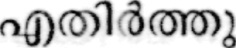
എതിര്‍ത്തു
